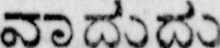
ವಾದುದು
